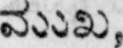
ಮುಖ,
